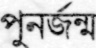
পুনর্জন্ম
